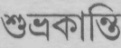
শুভ্ৰকান্তি
